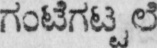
ಗಂಟೆಗಟ್ಟಲೆ
